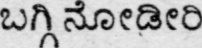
ಬಗ್ಗಿನೋಡೀರಿ
